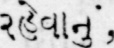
રહેવાનું,
